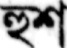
হুশ
